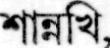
শান্নখি,
